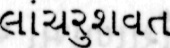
લાંચરુશવત
